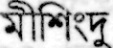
মীশিংদু
